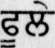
ਫੂਲੇ
